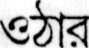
ওঠার
